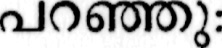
പറഞ്ഞു:
